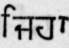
ਜਿਹਾ
